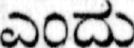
ಎಂದು
